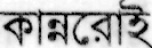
কান্নরোই
